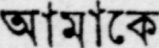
আমাকে
